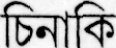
চিনাকি
